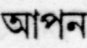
আপন
